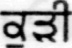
ਕੁੜੀ
